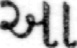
આ
